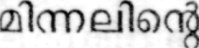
മിന്നലിന്റെ
